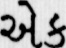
એક
